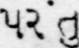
પરંતુ
